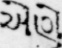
એણે
